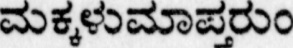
ಮಕ್ಕಳುಮಾಪ್ತರುಂ
